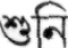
শুনি
